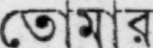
তোমার
